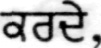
ਕਰਦੇ,
